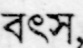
বত্স,
